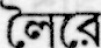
লৈরে
